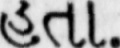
હતા.
